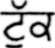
ਟੁੱਕ
